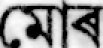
মোৰ
